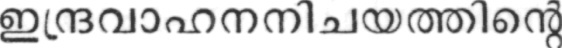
ഇന്ദ്രവാഹനനിചയത്തിന്റെ
